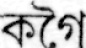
কগৈ
